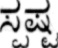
ಸ್ಪಷ್ಟ
